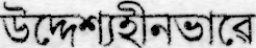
উদ্দেশ্যহীনভাৱে
